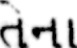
તેના
